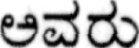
ಅವರು
